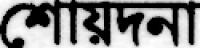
শোয়দনা
